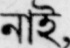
নাই,
